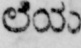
ಲೆಯ
